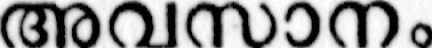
അവസാനം
